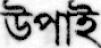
উপাই
